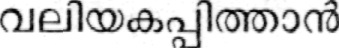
വലിയകപ്പിത്താന്‍
